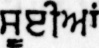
ਸੂਈਆਂ
